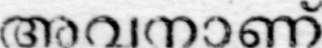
അവനാണ്
